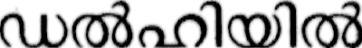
ഡല്‍ഹിയില്‍
